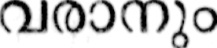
വരാനും
